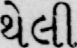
થેલી
